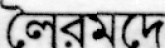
লৈরমদে
